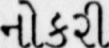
નોકરી
